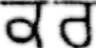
ਕਰ
